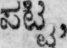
ಪಟ್ಟಿ,
